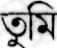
তুমি
